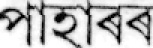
পাহাৰৰ
